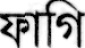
ফাগি
